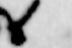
જ
